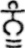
ਨੂੰ
